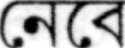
নেবে
